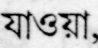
যাওয়া,
